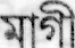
মাগী
